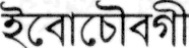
ইবোচৌবগী
